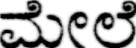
ಮೇಲೆ
